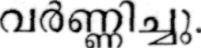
വര്‍ണ്ണിച്ചു.
